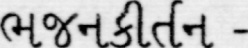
ભજનકીર્તન
